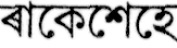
ৰাকেশেহে
